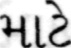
માટે
